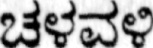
ಚಳವಳಿ
